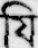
যি
